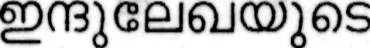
ഇന്ദുലേഖയുടെ
